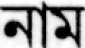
নাম
